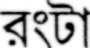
রংটা
